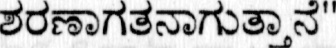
ಶರಣಾಗತನಾಗುತ್ತಾನೆ”
